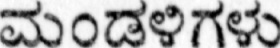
ಮಂಡಳಿಗಳು
